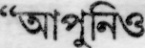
"আপুনিও
